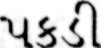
પકડી
